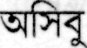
অসিবু
